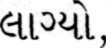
લાગ્યો,
